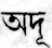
অদূ
